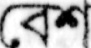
বেশ
